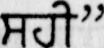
ਸਹੀ''
